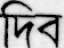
দিব
